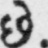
છે.
